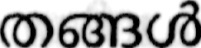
തങ്ങള്‍
